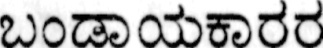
ಬಂಡಾಯಕಾರರ
